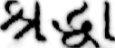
શ્રદ્ધા
